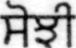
ਸੋਝੀ
